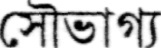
সৌভাগ্য
